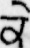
ਕੇ
